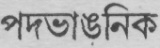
পদভাঙনিক
